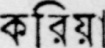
করিয়া
